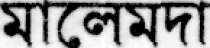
মালেমদা
